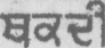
ਥਕਦੀ
